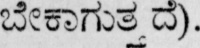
ಬೇಕಾಗುತ್ತದೆ).
